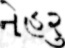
નેહરુ
